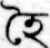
হৈ
